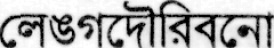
লেঙগদৌরিবনো
